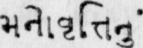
મનોવૃત્તિનું
